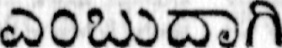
ಎಂಬುದಾಗಿ
